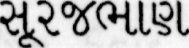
સૂરજભાણ
